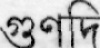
গুণদি
